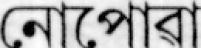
নোপোৱা
